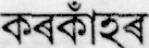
কৰকাঁহৰ
